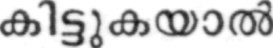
കിട്ടുകയാല്‍
